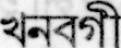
খনবগী
